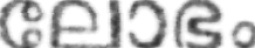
ലോഭം
